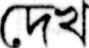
দেখ
